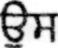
ਉਸ
